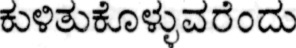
ಕುಳಿತುಕೊಳ್ಳುವರೆಂದು
